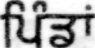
ਪਿੰਡਾਂ
